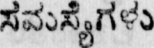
ಸಮಸ್ಯೆಗಳು
